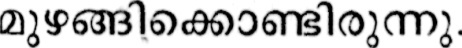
മുഴങ്ങിക്കൊണ്ടിരുന്നു.
